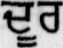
ਦੂਰ
